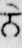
ਨੇ
